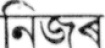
নিজৰ
